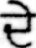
ਦੇ
